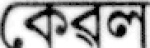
কেৱল
